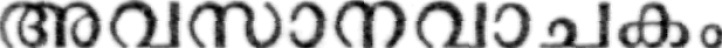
അവസാനവാചകം
